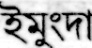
ইমুংদা
